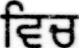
ਵਿਚ
